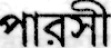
পারসী
